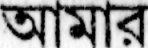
আমার
